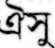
ঐসু
